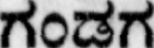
ಗಂಡಗ
